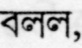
বলল,
